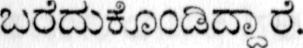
ಬರೆದುಕೊಂಡಿದ್ದಾರೆ.
